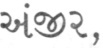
અંજીર,
